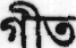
গীত
